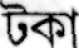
টকা
